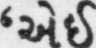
'એઈ
